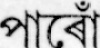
পাৰোঁ
